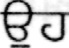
ਉਹ
